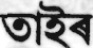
তাইৰ
